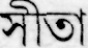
সীতা
